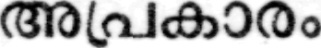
അപ്രകാരം
